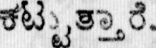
ಕಟ್ಟುತ್ತಾರೆ.
